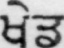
ਖੇਡ
